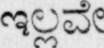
ಇಲ್ಲವೇ
